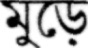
মুড়ে
